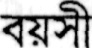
বয়সী
